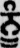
ਨੂੰ
